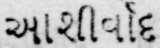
આશીર્વાદ
